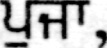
ਪੁਜਾ,
